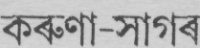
কৰুণা-সাগৰ
